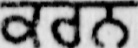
ਕਰਨ
